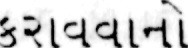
કરાવવાનો
